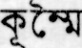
কূম্মৈ
